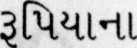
રૂપિયાના
